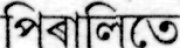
পিৰালিতে
